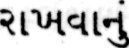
રાખવાનું
